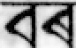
বৰ
